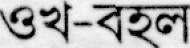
ওখ-বহল
